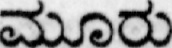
ಮೂರು
